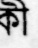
কী
